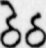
ઠેઠ
